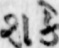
શકે
